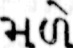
મળે
